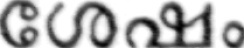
ശേഷം
